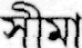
সীমা
